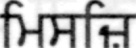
ਮਿਸਜ਼ਿ
